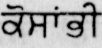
ਕੋਸਾਂਭੀ
